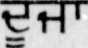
ਦੂਜਾ
